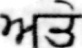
ਅਤੇ
